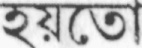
হয়তো
